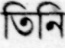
তিনি
